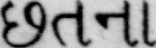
છતના
